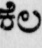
ಕೆಲ
